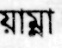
য়াম্না
